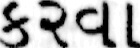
કરવા
